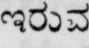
ಇರುವ
